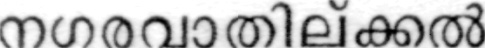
നഗരവാതില്ക്കല്‍
